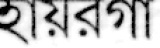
হায়রগা
